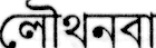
লৌথবা
